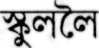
স্কুললৈ
